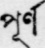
পূর্ণ
